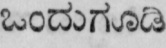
ಒಂದುಗೂಡಿ
